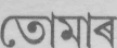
তোমাৰ
